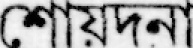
শোয়দনা
